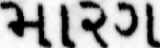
મારગ
